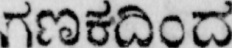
ಗಣಕದಿಂದ
